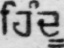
ਹਿੰਦੂ
